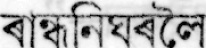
ৰান্ধনিঘৰলৈ
